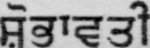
ਸ਼ੋਭਾਵਤੀ
